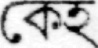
কেহ
